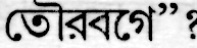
তৌরবগে”?
